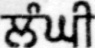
ਲੰਘੀ
